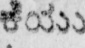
ಕೆಯು
